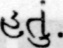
હતું.
